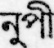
নুপী
